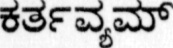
ಕರ್ತವ್ಯಮ್
